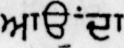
ਆਉਂਦਾ
